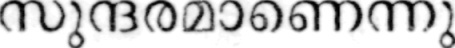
സുന്ദരമാണെന്നു
